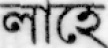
লাহে
